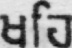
ਖਹਿ
